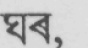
ঘৰ,
